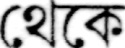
থেকে
